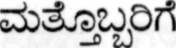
ಮತ್ತೊಬ್ಬರಿಗೆ
